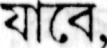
যাবে,
